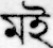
মই
